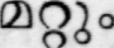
മറ്റും
